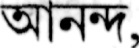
আনন্দ,
